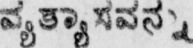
ವ್ಯತ್ಯಾಸವನ್ನು
